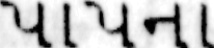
પાપના
